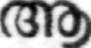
ആ
